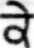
ਕੇ
